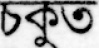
চকুত
